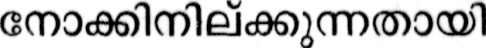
നോക്കിനില്ക്കുന്നതായി
